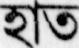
হাত
